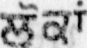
ਲੋਕਾਂ
